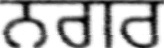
ਨਗਰ
